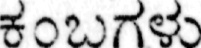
ಕಂಬಗಳು
